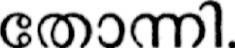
തോന്നി.
